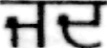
ਜਦ
